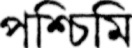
পশ্চিমি
